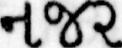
નજર
